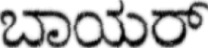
ಬಾಯರ್
